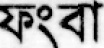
ফংবা
